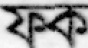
ফক
